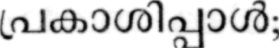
പ്രകാശിപ്പാള്‍;
